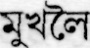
মুখলৈ
